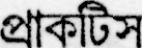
প্রাকটিস
